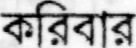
করিবার
